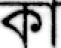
কা
